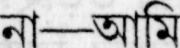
না-আমি
